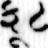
ફૂટ
